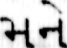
મને
